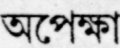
অপেক্ষা
